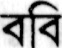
ববি
